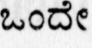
ಒಂದೇ
